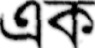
এক
